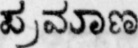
ಪ್ರಮಾಣ
